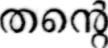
തന്റെ
